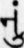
નું
